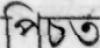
পিচত
